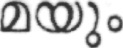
മയും
